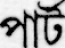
পার্ট
